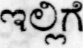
ಇಲ್ಲಿಗೆ
